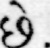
છે.
